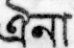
ঐনা
